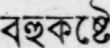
বহুকষ্টে
